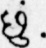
છું.
